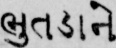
ભુતડાને
